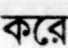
করে
